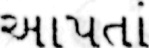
આપતાં
